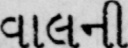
વાલની
